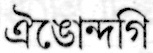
ঐঙোন্দগি
